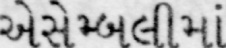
એસેમ્બલીમાં
